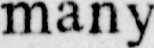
many
